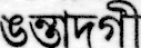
ঙন্তাদগী
